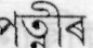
পত্নীৰ
